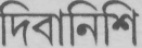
দিবানিশি
